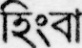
হিংবা
